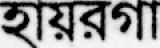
হায়রগা
